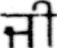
ਜੀ
